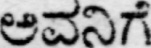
ಅವನಿಗೆ
